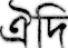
ঐদি
